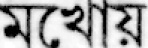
মখোয়
